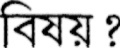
বিষয়?
